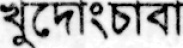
খুদোংচাবা
